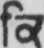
ਕਿ
